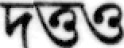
দত্তও
